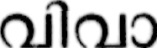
വിവാ
